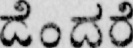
ದೆಂದರೆ
